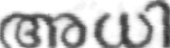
അധി
